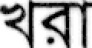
খরা
